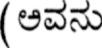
(ಅವನು
